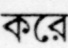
করে
